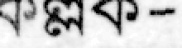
কল্লক-
